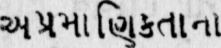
અપ્રમાણિકતાના
